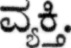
ವ್ಯಕ್ತಿ.
